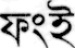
ফংই
